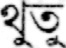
থুতু
